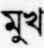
মুখ
